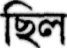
ছিল
